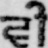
ਵੀ
